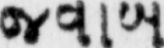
જવાબ
